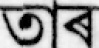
তাৰ
